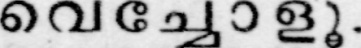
വെച്ചോളൂ.
